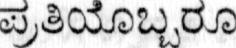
ಪ್ರತಿಯೊಬ್ಬರೂ
